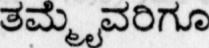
ತಮ್ಮೈವರಿಗೂ
